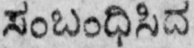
ಸಂಬಂಧಿಸಿದ
